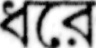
ধরে
